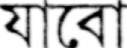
যাবো
